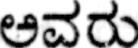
ಅವರು
